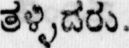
ತಳ್ಳಿದರು.
